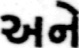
અને
